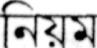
নিয়ম
